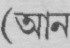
(আন
